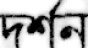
দর্শন
